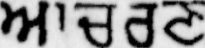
ਆਚਰਣ
